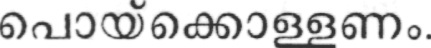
പൊയ്ക്കൊള്ളണം.
